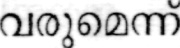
വരുമെന്ന്
